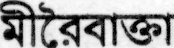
মীরৈবাক্তা
